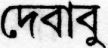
দেবাবু
